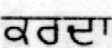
ਕਰਦਾ
